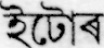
ইটোৰ
